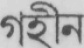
গহীন
